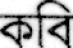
কবি
